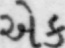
એક
